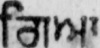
ਗਿਆ
